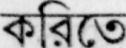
করিতে
